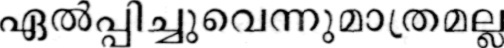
ഏല്‍പ്പിച്ചുവെന്നുമാത്രമല്ല
